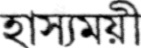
হাস্যময়ী
